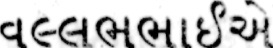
વલ્લભભાઈએ
